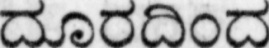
ದೂರದಿಂದ
